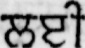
ਲਈ
